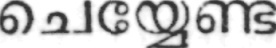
ചെയ്യേണ്ട
